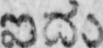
ಐದು
